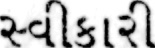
સ્વીકારી
